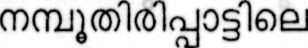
നമ്പൂതിരിപ്പാട്ടിലെ
